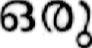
ഒരു
